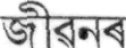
জীৱনৰ
